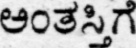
ಅಂತಸ್ತಿಗೆ
